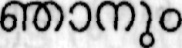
ഞാനും
